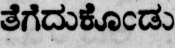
ತೆಗೆದುಕೊಂಡು
